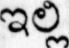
ಇಲ್ಲಿ
